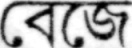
বেজে
